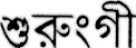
শুরুংগী
